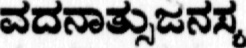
ವದನಾತ್ಸುಜನಸ್ಯ
